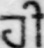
ਹੀ
